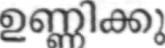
ഉണ്ണിക്കു
